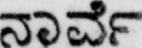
ನಾರ್ವೆ
